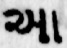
આ
